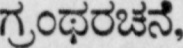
ಗ್ರಂಥರಚನೆ,
